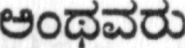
ಅಂಥವರು
